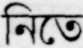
নিতে
